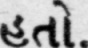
હતો.
